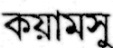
কয়ামসু
